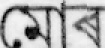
মোৰ
